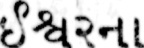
ઈશ્વરના
